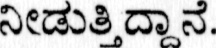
ನೀಡುತ್ತಿದ್ದಾನೆ.
